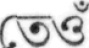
তেওঁ
